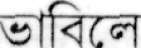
ভাবিলে
